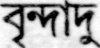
বৃন্দাদু
